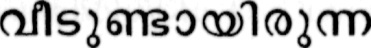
വീടുണ്ടായിരുന്ന
